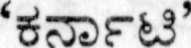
‘ಕರ್ನಾಟಿ’
